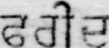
ਫਰੀਦ
